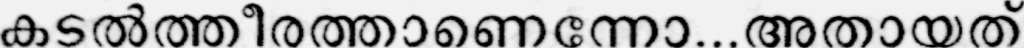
കടല്‍ത്തീരത്താണെന്നോ...അതായത്
